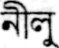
নীলু
